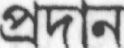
প্রদান
